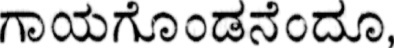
ಗಾಯಗೊಂಡನೆಂದೂ,
